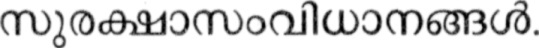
സുരക്ഷാസംവിധാനങ്ങള്‍.
